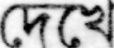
দেখে
